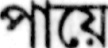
পায়ে
